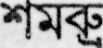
শমব্রু
